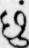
છું
